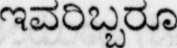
ಇವರಿಬ್ಬರೂ
